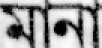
মানা
